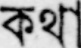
কথা
